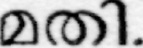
മതി.
